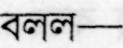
বলল–
